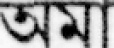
অমা
